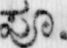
ಪೂ.
